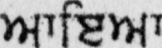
ਆਇਆ
